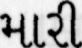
મારી
